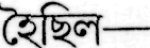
হৈছিল-
